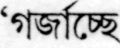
‘গর্জাচ্ছে
